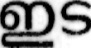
ഇട
